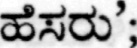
ಹೆಸರು’;
